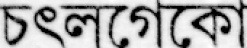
চৎলগেকো
